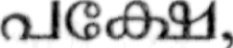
പക്ഷേ,
